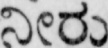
ನೀರು
